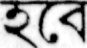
হবে
